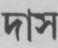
দাস
